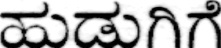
ಹುಡುಗಿಗೆ
